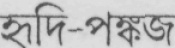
হৃদি-পঙ্কজ
